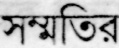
সম্মতির
